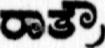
ರಾತ್ರೌ
